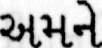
અમને
